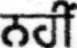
ਨਹੀਂ
